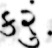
કરું.
